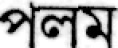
পলম
